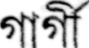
গার্গী
